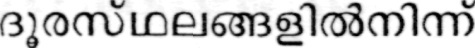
ദൂരസ്ഥലങ്ങളില്‍നിന്ന്
